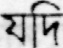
যদি
